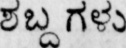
ಶಬ್ದಗಳು
